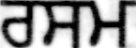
ਰਸਮ
